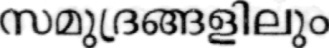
സമുദ്രങ്ങളിലും
